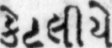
કેટલીયે
